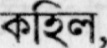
কহিল,
